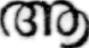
ആ
